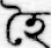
হৈ
